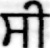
ਸੀ
